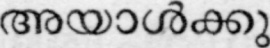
അയാള്‍ക്കു
